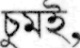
চুমই,
